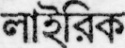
লাইরিক
